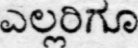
ಎಲ್ಲರಿಗೂ
